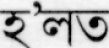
হ'লত
